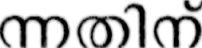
ന്നതിന്
